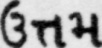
ઉત્તમ
